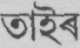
তাইৰ
